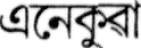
এনেকুৱা
